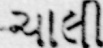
ચાલી
